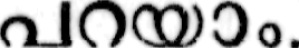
പറയാം.
